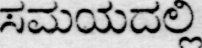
ಸಮಯದಲ್ಲಿ
